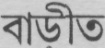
বাড়ীত
